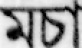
মচা
